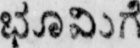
ಭೂಮಿಗೆ
